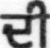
ਦੀ
